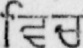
ਵਿਚ
